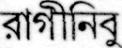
রাগীনিবু
